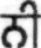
ਨੀ
